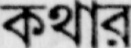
কথার
